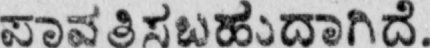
ಪಾವತಿಸಬಹುದಾಗಿದೆ.
